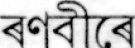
ৰণবীৰে
